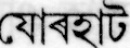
যোৰহাট
